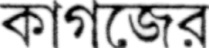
কাগজের
